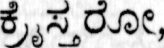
ಕ್ರೈಸ್ತರೋ,
